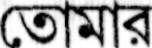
তোমার
